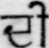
ਦੀ
